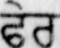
ਫੇਰ
